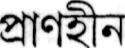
প্রাণহীন
